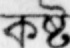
কষ্ট
